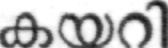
കയറി
